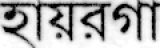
হায়রগা
